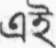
এই
